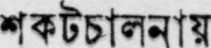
শকটচালনায়
